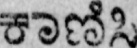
ಕಾಣಿಸಿ
